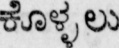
ಕೊಳ್ಳಲು
